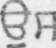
ਉਸ
